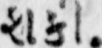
શકી.
